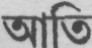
আতি
